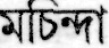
মচিন্দা
